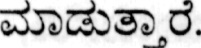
ಮಾಡುತ್ತಾರೆ.
